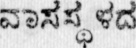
ವಾಸಸ್ಥಳದ
